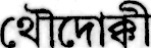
থৌদোক্কী
